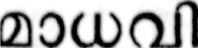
മാധവി
